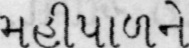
મહીપાળને
